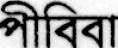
পীবিবা
